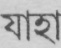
যাহা
